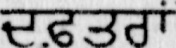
ਦਫ਼ਤਰਾਂ
